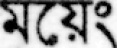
ময়েং
